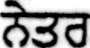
ਨੇਤਰ
